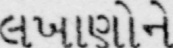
લખાણોને
